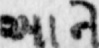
આને
